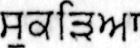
ਸੁਕੜਿਆ
